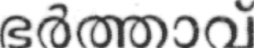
ഭര്‍ത്താവ്
